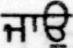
ਜਾਉ
